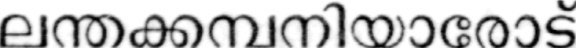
ലന്തക്കമ്പനിയാരോട്
